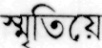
স্মৃতিয়ে
